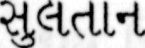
સુલતાન
